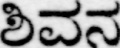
ಶಿವನ
